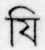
যি
